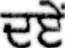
ਦਏਂ
